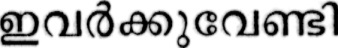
ഇവര്‍ക്കുവേണ്ടി
